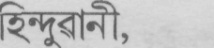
হিন্দুৱানী,
